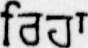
ਰਿਹਾ
